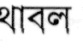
থাবল
